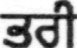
ਭਰੀ
